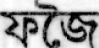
ফজৈ
